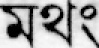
মথং
